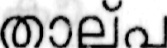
താല്പ
